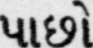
પાછો
